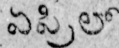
ಏಪ್ರಿಲ್
